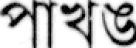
পাখঙ
